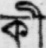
কী
